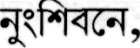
নুংশিবনে,
